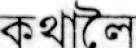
কথালৈ
